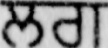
ਲਗ
